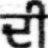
ਦੀ
